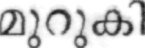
മുറുകി
